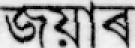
জয়াৰ
